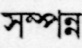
সম্পন্ন
